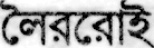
লৈররোই
